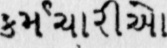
કર્મચારીઓ
